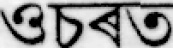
ওচৰত
